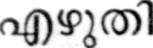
എഴുതി
